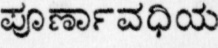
ಪೂರ್ಣಾವಧಿಯ
